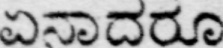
ಏನಾದರೂ
